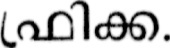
ഫ്രിക്ക.
